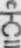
ਨੂੰ
